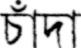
চাঁদা
